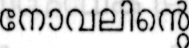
നോവലിന്റെ
